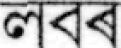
লবৰ
